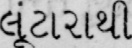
લૂંટારાથી
